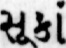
સૂકાં
